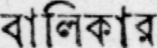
বালিকার
